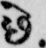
છે.
